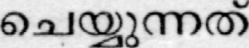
ചെയ്യുന്നത്
